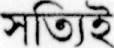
সত্যিই
